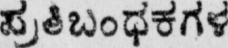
ಪ್ರತಿಬಂಧಕಗಳ
